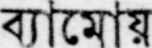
ব্যামোয়
